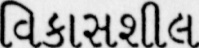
વિકાસશીલ
